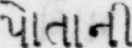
પોતાની
